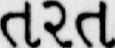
તરત
